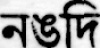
নঙদি
